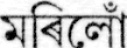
মৰিলোঁ
